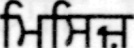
ਮਿਸਿਜ਼
